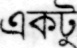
একটু
